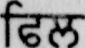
ਫਿਲ
